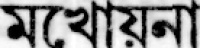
মখোয়না
